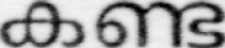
കണ്ട
